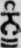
ਨੂੰ
